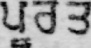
ਪੂਰਤ
